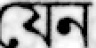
যেন
